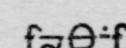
ਕਿਓਂ
